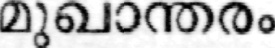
മുഖാന്തരം
